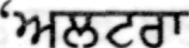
'ਅਲਟਰਾ
